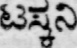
ಟಸ್ಕನಿ
